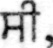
ਸੀ,
